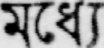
মধ্যে
